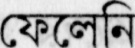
ফেলেনি
